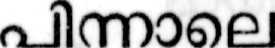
പിന്നാലെ
